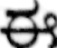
ಈ
